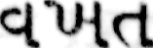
વખત
